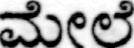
ಮೇಲೆ
